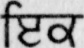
ਇਕ
